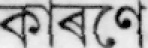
কাৰণে
